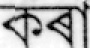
কৰা
